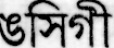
ঙসিগী
